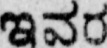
ಇವರ
